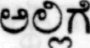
ಅಲ್ಲಿಗೆ
